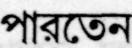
পারতেন
